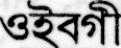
ওইবগী
